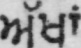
ਅੱਖਾਂ
